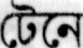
টেনে
